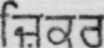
ਜ਼ਿਕਰ
